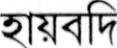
হায়বদি
